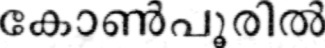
കോണ്‍പൂരില്‍
